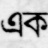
এক
